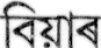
বিয়াৰ
